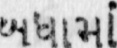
બધામાં
